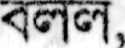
বলল,
